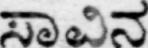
ಸಾವಿನ
